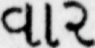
વાર
